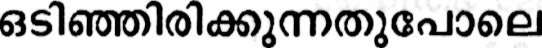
ഒടിഞ്ഞിരിക്കുന്നതുപോലെ
